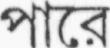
পারে
